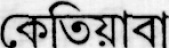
কেতিয়াবা
